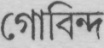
গোবিন্দ
